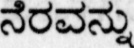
ನೆರವನ್ನು
